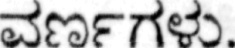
ವರ್ಣಗಳು.
